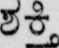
ಶಕ್ತಿ
